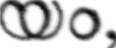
യം,
